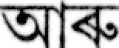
আৰু
